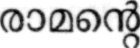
രാമന്റെ
